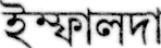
ইম্ফালদা
